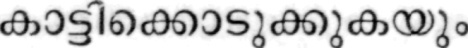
കാട്ടിക്കൊടുക്കുകയും
